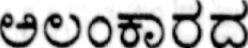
ಅಲಂಕಾರದ
